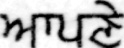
ਆਪਣੇ
